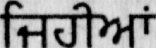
ਜਿਹੀਆਂ
